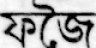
ফজৈ
